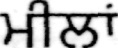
ਮੀਲਾਂ
